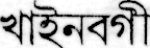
খাইনবগী
